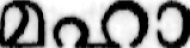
മഹാ
